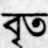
বৃত
